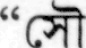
"সৌ
